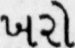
ખરો
